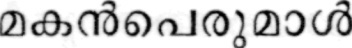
മകന്‍പെരുമാള്‍
